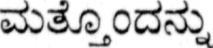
ಮತ್ತೊಂದನ್ನು
